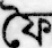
ফৈ
